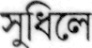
সুধিলে
